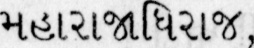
મહારાજાધિરાજ,
